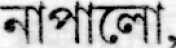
নাপালো,
